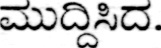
ಮುದ್ದಿಸಿದ.
